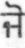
ਜੋ
